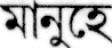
মানুহে
